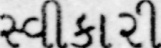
સ્વીકારી
